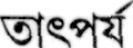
তাৎপর্য
